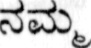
ನಮ್ಮ
